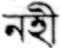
নহী
